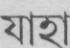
যাহা
